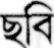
ছবি
